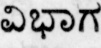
ವಿಭಾಗ
